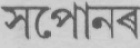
সপোনৰ
